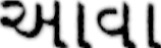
આવા
